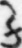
કે
